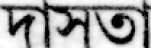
দাসতা
